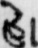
હો
